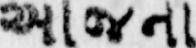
આજના
